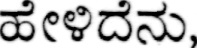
ಹೇಳಿದೆನು,
